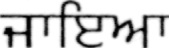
ਜਾਇਆ
